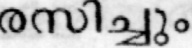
രസിച്ചും
